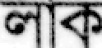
লাক
